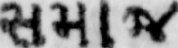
સમાજ
